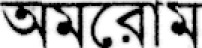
অমরোম
